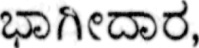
ಭಾಗೀದಾರ,
